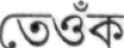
তেওঁক
